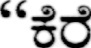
"ಕೆರೆ
